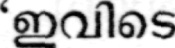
‘ഇവിടെ
